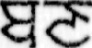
ਬਣ
